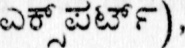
ಎಕ್ಸ್‌ಪರ್ಟ್),
